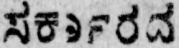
ಸರ್ಕಾರದ
